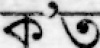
ক'ত
